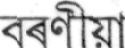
বৰণীয়া
